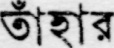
তাঁহার
